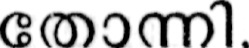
തോന്നി.
